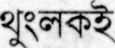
থুংলকই
